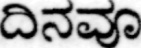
ದಿನವೂ
